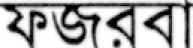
ফজরবা
